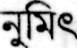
নুমিৎ
